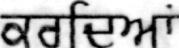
ਕਰਦਿਆਂ
